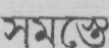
সমস্তে
